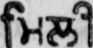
ਮਿਲੀ
